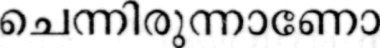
ചെന്നിരുന്നാണോ
